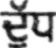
ਦੁੱਧ
